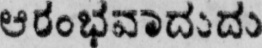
ಆರಂಭವಾದುದು
